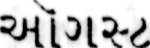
ઑગસ્ટ
